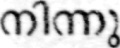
നിന്നു
